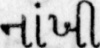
નાંખી
